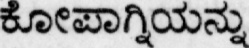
ಕೋಪಾಗ್ನಿಯನ್ನು
